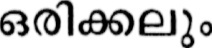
ഒരിക്കലും
